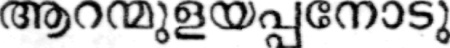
ആറന്മുളയപ്പനോടു
